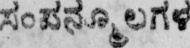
ಸಂಪನ್ಮೂಲಗಳ
